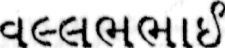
વલ્લભભાઈ
